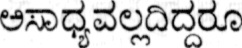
ಅಸಾಧ್ಯವಲ್ಲದಿದ್ದರೂ
